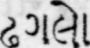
ઢગલો
